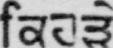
ਕਿਹੜੇ
